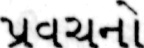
પ્રવચનો
